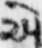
એ
